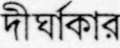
দীর্ঘাকার
